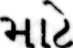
માટે
